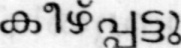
കീഴ്പ്പട്ടു
